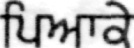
ਪਿਆਕੇ
